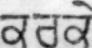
ਕਰਕੇ
